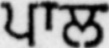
ਪਾਲ
